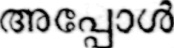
അപ്പോള്‍
